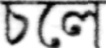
চলে
